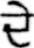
ਦੇ
